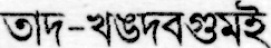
তাদ-খঙদবগুমই
